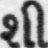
શી
